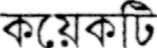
কয়েকটি
